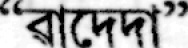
“ৱাদেদা”
